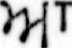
ਆ
